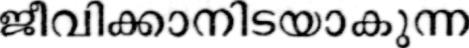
ജീവിക്കാനിടയാകുന്ന
